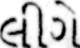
લીગે
